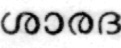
ശാരദ
